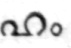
ഹം
